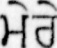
ਮੇਰੇ
